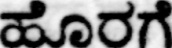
ಹೊರಗೆ
